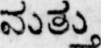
ಮತ್ತು
